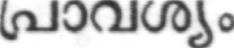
പ്രാവശ്യം
